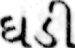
ઘડી
